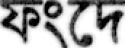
ফংদে
